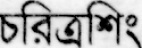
চরিত্রশিং
